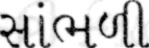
સાંભળી
